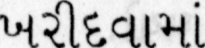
ખરીદવામાં
